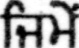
ਜਿਮੇਂ
